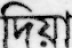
দিয়া
